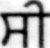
ਸੀ
